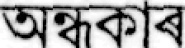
অন্ধকাৰ
